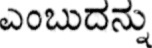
ಎಂಬುದನ್ನು
